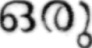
ഒരു
